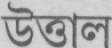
উত্তাল
